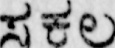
ಸಕಲ
